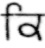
ਕਿ
